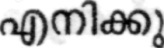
എനിക്കു
